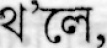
থ'লে,
